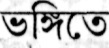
ভঙ্গিতে
